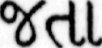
જતા
